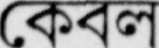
কেবল
